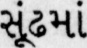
સૂંઢમાં
